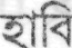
হাবি
